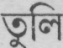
তুলি
